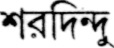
শরদিন্দু
